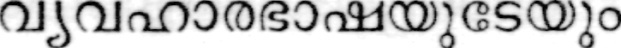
വ്യവഹാരഭാഷയുടേയും
